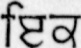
ਇਕ
